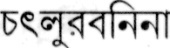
চৎলুরবনিনা
